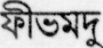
ফীভমদু
